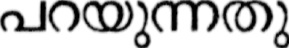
പറയുന്നതു
